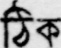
ঠিক
